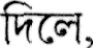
দিলে,
